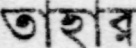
তাহার
